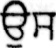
ਉਸ
